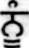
ਨੂੰ
